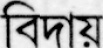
বিদায়
